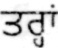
ਤਰ੍ਹਾਂ
